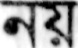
নয়
